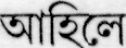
আহিলে
